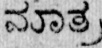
ಮಾತ್ರ
